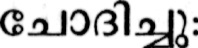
ചോദിച്ചു:
